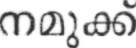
നമുക്ക്
